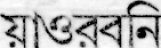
য়াওরবনি
